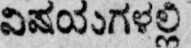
ವಿಷಯಗಳಲ್ಲಿ
